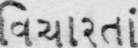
વિચારતાં
